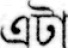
এটা
